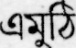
এমুঠি
